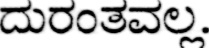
ದುರಂತವಲ್ಲ.
